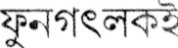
ফুনগৎলকই
